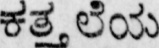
ಕತ್ತಲೆಯ
